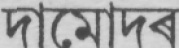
দামোদৰ
